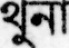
থুনা
